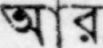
আর
